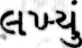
લખ્યું
